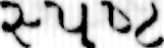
સ્પષ્ટ
